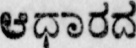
ಆಧಾರದ
